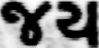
જય
